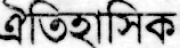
ঐতিহাসিক
